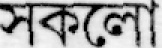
সকলো
